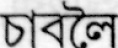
চাবলৈ
